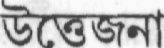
উত্তেজনা
